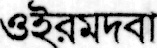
ওইরমদবা
